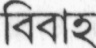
বিবাহ
